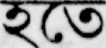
হতে
